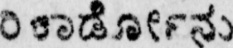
ರಿಕಾರ್ಡೋನು
